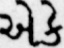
એકે
